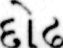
દોઢ
